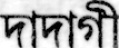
দাদাগী
